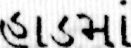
હાડમાં
